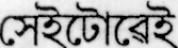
সেইটোৱেই
